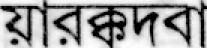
য়ারক্কদবা
